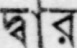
দ্বার
